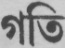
গতি
